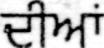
ਦੀਆਂ
